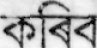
কৰিব
